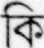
কি
